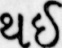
થઈ
